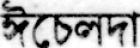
ঈচেলদা
